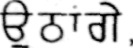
ਉਠਾਂਗੇ,
